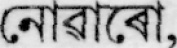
নোৱাৰো,
